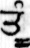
ਤੂੰ
